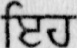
ਇਹ
